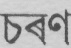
চৰণ
